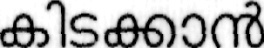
കിടക്കാന്‍
